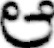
ಆ
